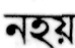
নহয়
